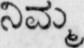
ನಿಮ್ಮ
